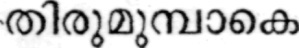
തിരുമുമ്പാകെ
